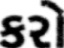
કરો
